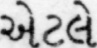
એટલે
